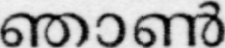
ഞാണ്‍
